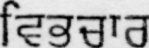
ਵਿਭਚਾਰ
